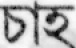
চাহ
